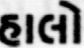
હાલો
